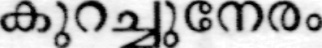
കുറച്ചുനേരം
